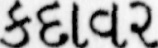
કદાવર
